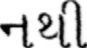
નથી
